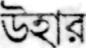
উহার
